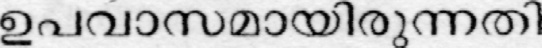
ഉപവാസമായിരുന്നതി
